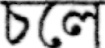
চলে
